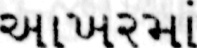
આખરમાં
